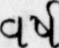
વર્ષ
